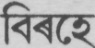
বিৰহে
